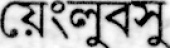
য়েংলুবসু
